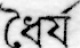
ধৈর্য
